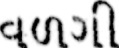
વળગી
